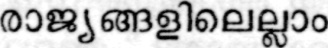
രാജ്യങ്ങളിലെല്ലാം
